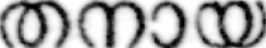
തനായ
